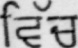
ਵਿੱਚ
